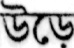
উড়ে
